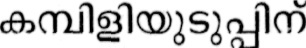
കമ്പിളിയുടുപ്പിന്
